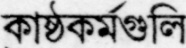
কাষ্ঠকর্মগুলি
